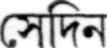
সেদিন
